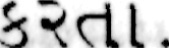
કરતા.
